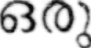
ഒരു
